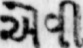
એવી
